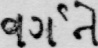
વર્ગને
